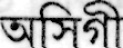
অসিগী
